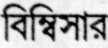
বিম্বিসার
